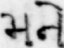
મને
